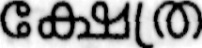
ക്ഷേത്ര
